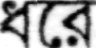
ধরে
